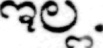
ಇಲ್ಲ.
